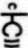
ਨੂੰ
